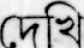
দেখি
